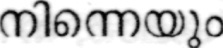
നിന്നെയും
